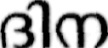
ദിന
